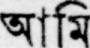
আমি
